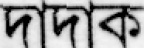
দাদাক
